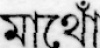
মাথোঁ
